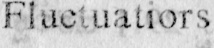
Fluetuatiors
